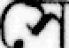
সে
